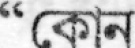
"কোন
